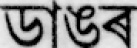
ডাঙৰ
